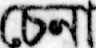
চেনা
